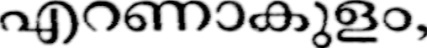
എറണാകുളം,
